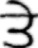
ਤੇ
